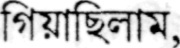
গিয়াছিলাম,
